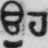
ਉਹ
